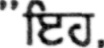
''ਇਹ,
